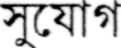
সুযোগ
